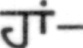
ਹਾਂ-
